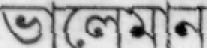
ভালেমান
